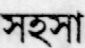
সহসা
